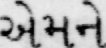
એમને
